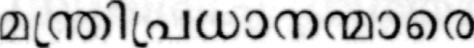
മന്ത്രിപ്രധാനന്മാരെ
